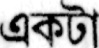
একটা
